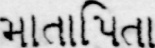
માતાપિતા
